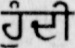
ਹੁੰਦੀ
